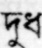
দুধ
